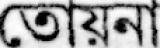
তোয়না
